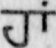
ਹਾਂ
